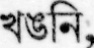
খঙনি,
